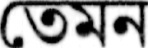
তেমন
